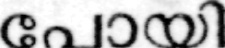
പോയി
